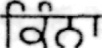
ਕਿੰਨਾ
